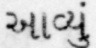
આવ્યું
